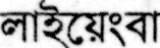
লাইয়েংবা
